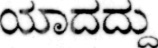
ಯಾದದ್ದು
